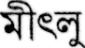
মীৎলু
